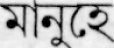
মানুহে
